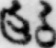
હઠ
